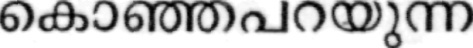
കൊഞ്ഞപറയുന്ന
